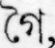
গৈ,
